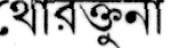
থোরক্তুনা
